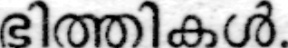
ഭിത്തികള്‍.
